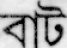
বাট
